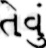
તેવું
